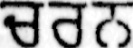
ਚਰਨ
